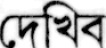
দেখিব
